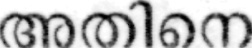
അതിനെ
